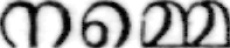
നമ്മെ
